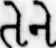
તેને
